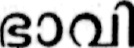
ഭാവി
